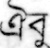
ঐবু
